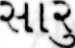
સારુ
